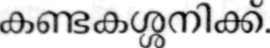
കണ്ടകശ്ശനിക്ക്.
